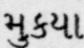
મુકયા
